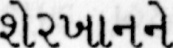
શેરખાનને
